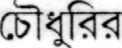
চৌধুরির
